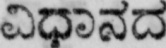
ವಿಧಾನದ
